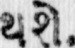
થશે.
